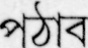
পঠাব
